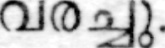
വരച്ചു.
